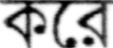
করে
